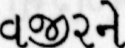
વજીરને
